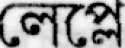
লেপ্লে
